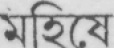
মহিষে
